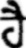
ਹੈ
